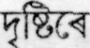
দৃষ্টিৰে
